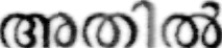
അതില്‍
